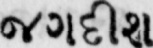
જગદીશ
